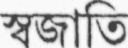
স্বজাতি
